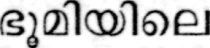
ഭൂമിയിലെ
